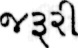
જરૂરી
